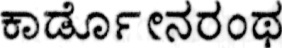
ಕಾರ್ಡೋನರಂಥ
